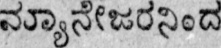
ಮ್ಯಾನೇಜರನಿಂದ
